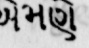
એમણે
